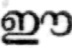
ഈ
